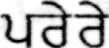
ਪਰੇਰੇ
